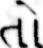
તો
